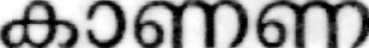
കാണണ
